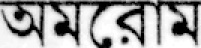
অমরোম
